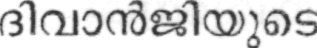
ദിവാന്‍ജിയുടെ
